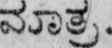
ಮಾತ್ರ.
